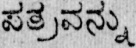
ಪತ್ರವನ್ನು
